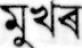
মুখৰ
